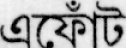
এফোঁট
